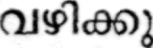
വഴിക്കു
